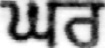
ਘਰ
